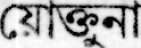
য়োক্তুনা
